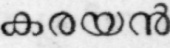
കരയന്‍
